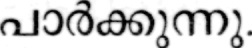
പാര്‍ക്കുന്നു.
